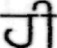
ਹੀ
